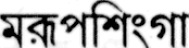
মরূপশিংগা
